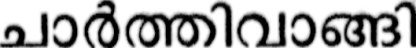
ചാര്‍ത്തിവാങ്ങി
